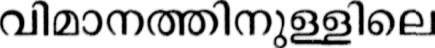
വിമാനത്തിനുള്ളിലെ
